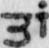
ਤਾਂ
